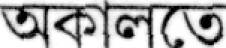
অকালতে
